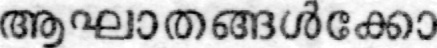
ആഘാതങ്ങള്‍ക്കോ
